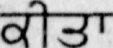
ਕੀਤਾ
